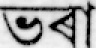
ভৰা
